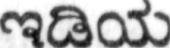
ಇಡಿಯ
